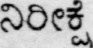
ನಿರೀಕ್ಷೆ
